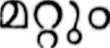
മറ്റും
